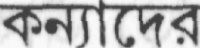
কন্যাদের
